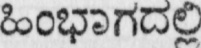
ಹಿಂಭಾಗದಲ್ಲಿ
